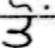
ਤੋਂ
